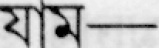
যাম-
